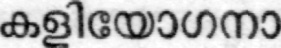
കളിയോഗനാ
